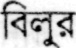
বিলুর
